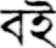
বই
